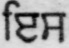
ਇਸ
